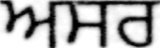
ਅਸਰ
